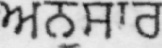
ਅਨੁਸਾਰ
